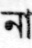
না
